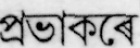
প্রভাকৰে
